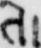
તો
